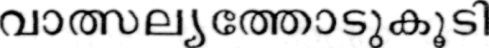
വാത്സല്യത്തോടുകൂടി
